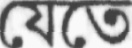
যেতে
